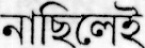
নাছিলেই
